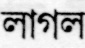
লাগল
